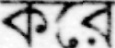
করে
